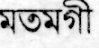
মতমগী
